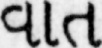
વાત
